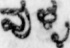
ವುಳ್ಳ
